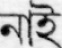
নাই
